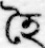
হৈ
